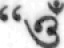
"ওঁ
